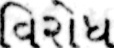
વિરોધ
